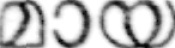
മായ
